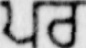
ਪਰ
